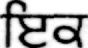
ਇਕ
